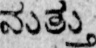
ಮತ್ತು
